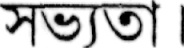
সভ্যতা।
